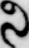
ನಿ
